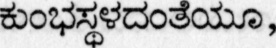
ಕುಂಭಸ್ಥಳದಂತೆಯೂ,
